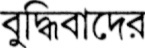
বুদ্ধিবাদের
